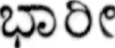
ಭಾರೀ
